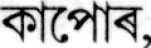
কাপোৰ,
